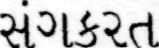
સંગકરત
